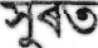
সুৰত
